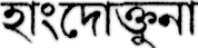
হাংদোক্তুনা
